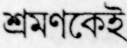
শ্রমণকেই
